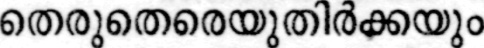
തെരുതെരെയുതിര്‍ക്കയും
